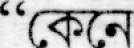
"কেনে
